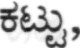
ಕಟ್ಟು,
